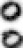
ঃ
